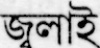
জ্বলাই
